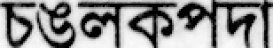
চঙলকপদা
